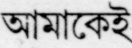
আমাকেই
